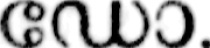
ഡോ.
